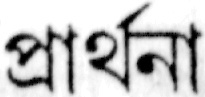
প্রার্থনা
